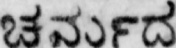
ಚರ್ಮದ
